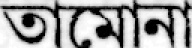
তামোনা
